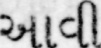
આવી
